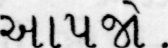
આપજો.
